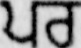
ਪਰ
